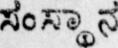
ಸಂಸ್ಥಾನ
